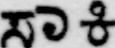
ಸಾಕಿ
